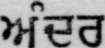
ਅੰਦਰ
